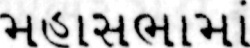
મહાસભામાં
